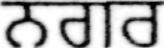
ਨਗਰ
